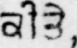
ਕੀਤੇ,
